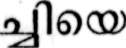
ച്ചിയെ
